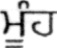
ਮੂੰਹ
